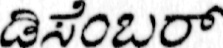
ಡಿಸೆಂಬರ್
